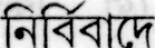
নির্বিবাদে
